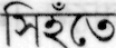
সিহঁতে
